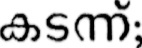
കടന്ന്;
